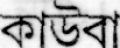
কাউবা
